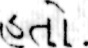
હતો.
